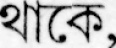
থাকে,
